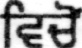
ਵਿਚੋਂ
